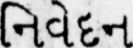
નિવેદન
